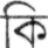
কি
